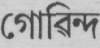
গোৱিন্দ
